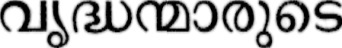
വൃദ്ധന്മാരുടെ
